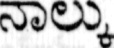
ನಾಲ್ಕು
